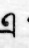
এ
